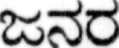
ಜನರ
